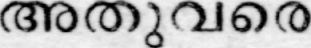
അതുവരെ
